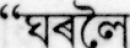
"ঘৰলৈ
